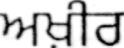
ਅਖ਼ੀਰ
